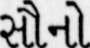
સૌનો
